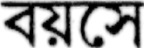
বয়সে
